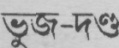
ভুজ-দণ্ড
